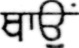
ਥਾਉਂ
